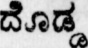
ದೊಡ್ಡ
